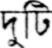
দুটি
